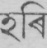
হৰি
